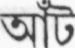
আঁট
